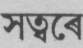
সত্বৰে
